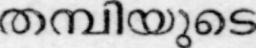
തമ്പിയുടെ
